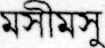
মসীমসু
